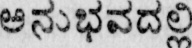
ಅನುಭವದಲ್ಲಿ
